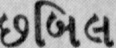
છબિલ
